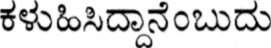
ಕಳುಹಿಸಿದ್ದಾನೆಂಬುದು
